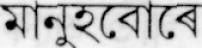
মানুহবোৰে
